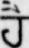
ਹੈ
